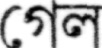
গেল
